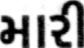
મારી
